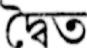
দ্বৈত
